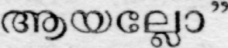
ആയല്ലോ”
